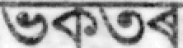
ভকতৰ
